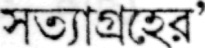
সত্যাগ্রহের’
